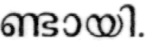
ണ്ടായി.
